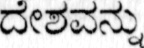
ದೇಶವನ್ನು
